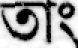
তাং
